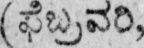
(ಫೆಬ್ರವರಿ,
